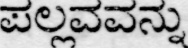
ಪಲ್ಲವವನ್ನು
